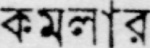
কমলার
